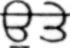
ਉਤੇ
